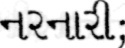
નરનારી;
